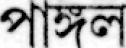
পাঙ্গল
